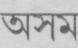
অসম
